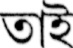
তাই
